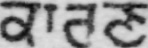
ਕਾਰਣ
